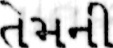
તેમની
